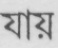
যায়
